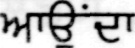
ਆਉਂਦਾ
